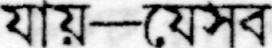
যায়—যেসব
